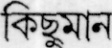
কিছুমান
